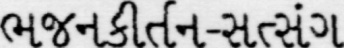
ભજનકીર્તન-સત્સંગ
